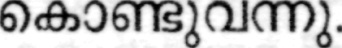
കൊണ്ടുവന്നു.
